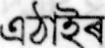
এঠাইৰ
